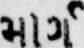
માર્ગ
